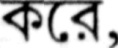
করে,
